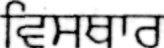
ਵਿਸਥਾਰ
